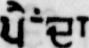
ਪੈਂਦਾ
